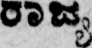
ರಾಜ್ಯ
